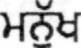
ਮਨੁੱਖ
